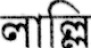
লাল্লি
